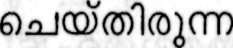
ചെയ്തിരുന്ന
